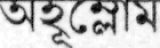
অহূম্লোল
